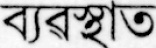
ব্যৱস্থাত
